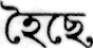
হৈছে,
